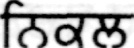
ਨਿਕਲ
